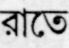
রাতে
